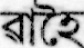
ৱাহৈ
